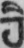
ਹੈ
